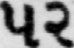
પર
